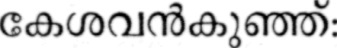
കേശവന്‍കുഞ്ഞ്:
